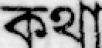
কথা
